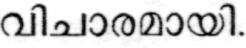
വിചാരമായി.
